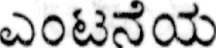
ಎಂಟನೆಯ
